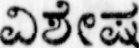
ವಿಶೇಷ
